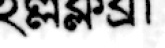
হল্লক্লব্রা
